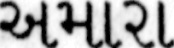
અમારા
